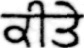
ਕੀਤੇ
